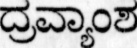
ದ್ರವ್ಯಾಂಶ
